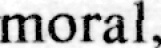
moral,
